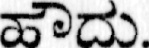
ಹೌದು.
